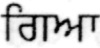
ਗਿਆ
